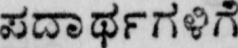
ಪದಾರ್ಥಗಳಿಗೆ
